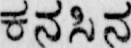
ಕನಸಿನ
